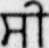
ਸੀ
